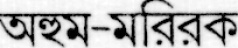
অহুম-মরিরক
